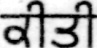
ਕੀਤੀ
